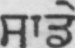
ਸਾਡੇ
